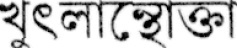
খুৎলান্থোক্তা
